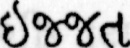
ઇજ્જત
